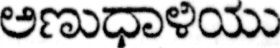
ಅಣುಧಾಳಿಯು
